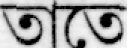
তাতে
